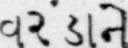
વરંડાને
